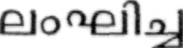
ലംഘിച്ച
